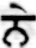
ਨੇ
